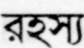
রহস্য
